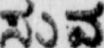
ಸುವ
